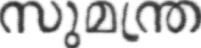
സുമന്ത്ര
